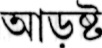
আড়ষ্ট
